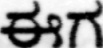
ಈಗ
